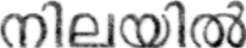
നിലയില്‍
